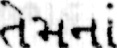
તેમનાં
